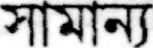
সামান্য
